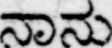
ನಾನು
